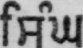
ਸਿੰਘ
